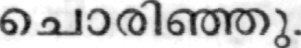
ചൊരിഞ്ഞു.
